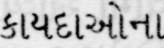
કાયદાઓના
